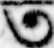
ত
